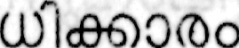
ധിക്കാരം
